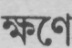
ক্ষণে
